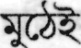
মুঠেই
